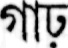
গাঢ়
